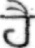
ਹੈ
